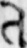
તે
